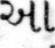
આ
